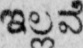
ಇಲ್ಲವೆ
